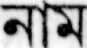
নাম
